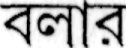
বলার
